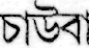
চাউবা
